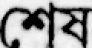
শেষ
